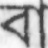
বা
